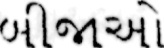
બીજાઓ
